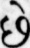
છે
